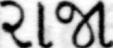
રાજા
